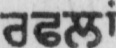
ਰਫਲਾਂ
